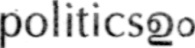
politicsഉം
